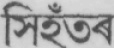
সিহঁতৰ
